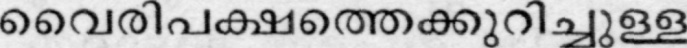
വൈരിപക്ഷത്തെക്കുറിച്ചുള്ള
